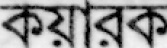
কয়ারক
